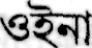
ওইনা
